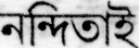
নন্দিতাই
